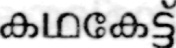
കഥകേട്ട്
